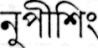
নুপীশিং
